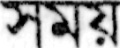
সময়
